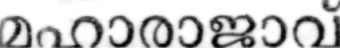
മഹാരാജാവ്
